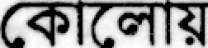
কোলোয়
